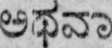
ಅಥವಾ
